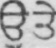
ਉਤੇ
